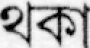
থকা
